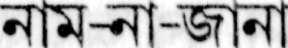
নাম-না-জানা
